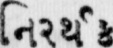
નિરર્થક
